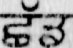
ਛੱਡ
